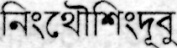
নিংথৌশিংদূবু
